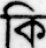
কি
